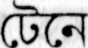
টেনে
